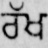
ਰੱਖ
